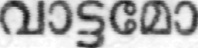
വാട്ടമോ
